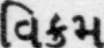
વિક્રમ
